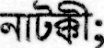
নাটক্কী;
